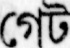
গেট
